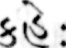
કહે:
